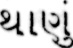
થાણું
